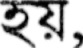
হয়,
